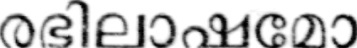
രഭിലാഷമോ
